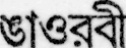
ঙাওরবী
